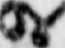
જ
